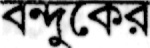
বন্দুকের
